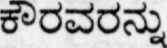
ಕೌರವರನ್ನು
